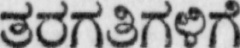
ತರಗತಿಗಳಿಗೆ
